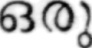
ഒരു
